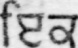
ਇਕ
